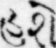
હશે
